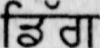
ਡਿੱਗ
